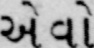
એવો
